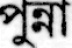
পুন্না
